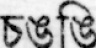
চঙঙি
